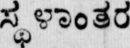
ಸ್ಥಳಾಂತರ
